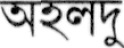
অহলদু
